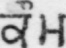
ਕੌਮ
